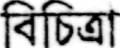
বিচিত্রা
